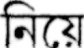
নিয়ে
